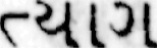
ત્યાગ
